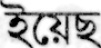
ইয়েছ
